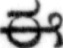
ಈ
